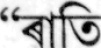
"ৰাতি
